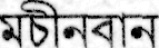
মচীনবান
